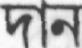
দান
